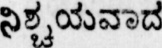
ನಿಶ್ಚಯವಾದ
